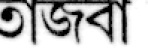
তাজবা
